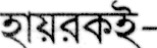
হায়রকই-
